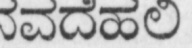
ನವದೆಹಲಿ
